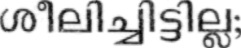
ശീലിച്ചിട്ടില്ല;
